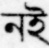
নই
